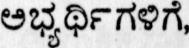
ಅಭ್ಯರ್ಥಿಗಳಿಗೆ,
